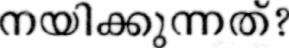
നയിക്കുന്നത്?
